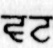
ਵਟ
